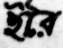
ইরৈ
